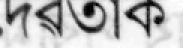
দেৱতাক
